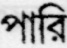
পারি
